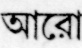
আরো
